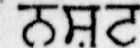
ਨਸ਼ਟ
